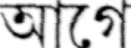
আগে
